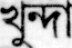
খুন্দা
